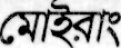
মোইরাং
